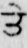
ਤੇ
